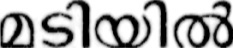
മടിയില്‍
